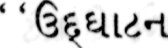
"ઉદ્ઘાટન
